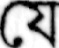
যে
